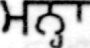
ਮਨ੍ਹਾ
